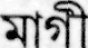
মাগী
